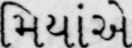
મિયાંએ
